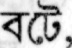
বটে,
